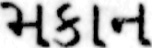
મકાન
